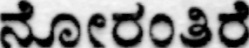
ನೋರಂತಿರೆ
